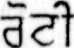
ਰੋਟੀ
